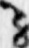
કે
